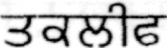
ਤਕਲੀਫ਼
